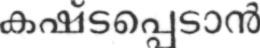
കഷ്ടപ്പെടാന്‍
